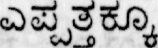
ಎಪ್ಪತ್ತಕ್ಕೂ
